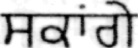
ਸਕਾਂਗੇ
